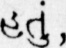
હતું,
